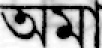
অমা
